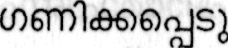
ഗണിക്കപ്പെടു
